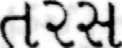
તરસ
